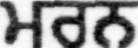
ਮਰਨ
